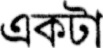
একটা
